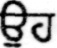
ਉਹ
